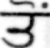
ਤੋਂ
